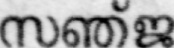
സഞ്ജ
